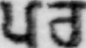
ਪਰ
